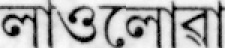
লাওলোৱা
